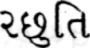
રછુતિ
